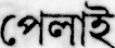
পেলাই
